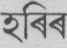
হৰিৰ
